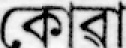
কোৱা
